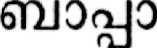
ബാപ്പാ
